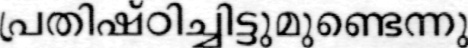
പ്രതിഷ്ഠിച്ചിട്ടുമുണ്ടെന്നു
